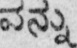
ವನ್ನು
